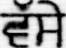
ਵੱਸੇ
